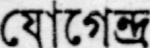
যোগেন্দ্র
